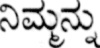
ನಿಮ್ಮನ್ನು
